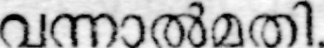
വന്നാല്‍മതി.
